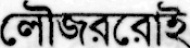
লৌজররোই
